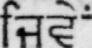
ਜਿਵੇਂ
